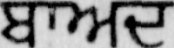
ਬਾਅਦ
